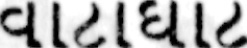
વાટાઘાટ
